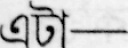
এটা-
